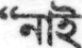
"নাই
